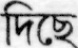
দিছে
